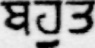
ਬਹੁਤ
